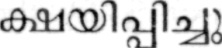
ക്ഷയിപ്പിച്ചു
